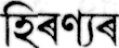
হিৰণ্যৰ
